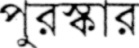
পুরস্কার
